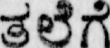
ತಲೆಗೆ
